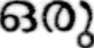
ഒരു
